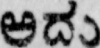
ಅದು
